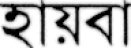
হায়বা
